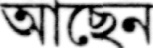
আছেন
